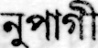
নুপাগী
